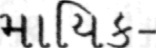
માયિક-
